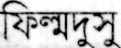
ফিল্মদুসু
